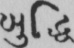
બુદ્ધિ
